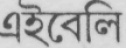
এইবেলি
